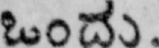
ಒಂದು.
